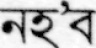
নহ'ব
